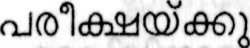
പരീക്ഷയ്ക്കു
